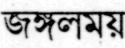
জঙ্গলময়
